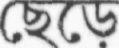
ছেড়ে
